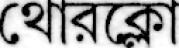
থোরক্লো
